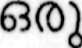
ഒരു
